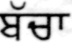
ਬੱਚਾ
